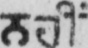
ਨਹੀਂ
